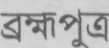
ব্ৰহ্মপুত্র
